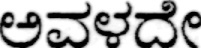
ಅವಳದೇ
